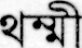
থম্মী
